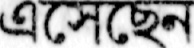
এসেছেন
